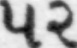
પર
